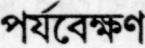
পর্যবেক্ষণ
